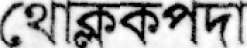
থোক্লকপদা
